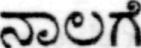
ನಾಲಗೆ
